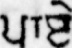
ਪਾਏ
